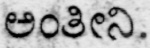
ಅಂತೀನಿ.
